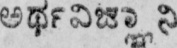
ಅರ್ಥವಿಜ್ಞಾನಿ
